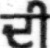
ਦੀ
